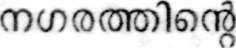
നഗരത്തിന്റെ
